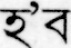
হ'ব
